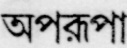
অপরূপা
